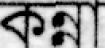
কন্না
